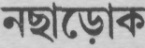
নছাড়োক
